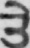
ਤੇ
